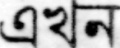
এখন
